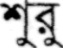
শুরু
